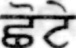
ਛੋਟੇ
